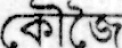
কৌজৈ
